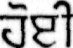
ਹੋਈ
